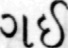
ગઈ
